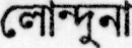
লোন্দুনা
